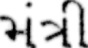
મંત્રી
